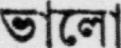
ভালো
